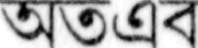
অতএব
